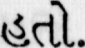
હતો.
